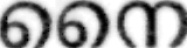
നൈ
